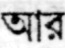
আর
